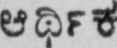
ಆರ್ಥಿಕ
